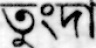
তুংদা
